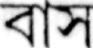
বাস
